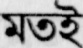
মতই
